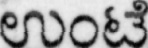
ಉಂಟೆ
